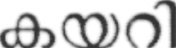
കയറി
